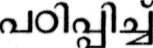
പഠിപ്പിച്ച്
